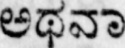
ಅಥವಾ
